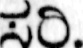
ಸರಿ.
